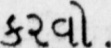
કરવો.
